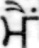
ਮੈਂ
